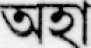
অহা
